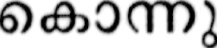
കൊന്നു
